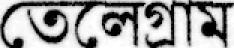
তেলেগ্রাম
